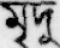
মৃদু
